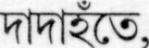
দাদাহঁতে,
